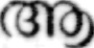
ആ
